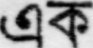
এক
